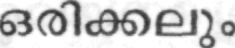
ഒരിക്കലും
